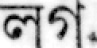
লগ
